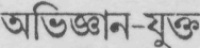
অভিজ্ঞান-যুক্ত
